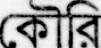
কৌরি
